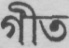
গীত
